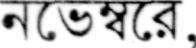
নভেম্বরে,
